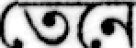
তেনে
